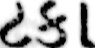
ટકા
